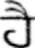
ਹੈ
